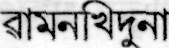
ৱামনখিদুনা
